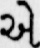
એ
